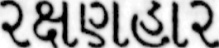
રક્ષણહાર
